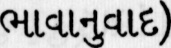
ભાવાનુવાદ)
